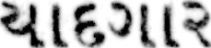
યાદગાર
